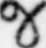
જ
